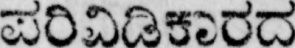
ಪರಿವಿಡಿಕಾರದ
